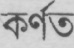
কৰ্ণত
